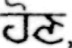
ਹੋਣ,
